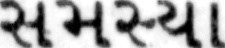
સમસ્યા
